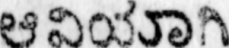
ಆವಿಯಾಗಿ
